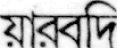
য়ারদি
